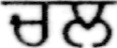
ਚਲ
